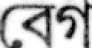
বেগ
